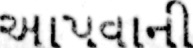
આપવાની
